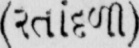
(રતાંદળ)
